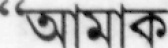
"আমাক
